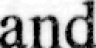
and
